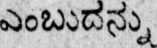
ಎಂಬುದನ್ನು
